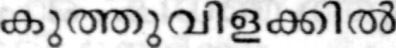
കുത്തുവിളക്കില്‍
